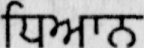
ਧਿਆਨ
